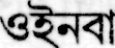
ওইনবা
